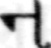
ન
